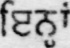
ਇਨ੍ਹਾਂ
